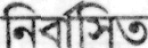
নিৰ্বাসিত
